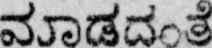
ಮಾಡದಂತೆ
